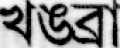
খঙব্রা
